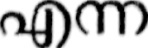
എന്ന
